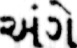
અંગે
